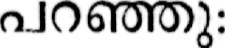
പറഞ്ഞു:
